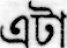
এটা
